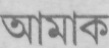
আমাক
